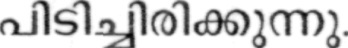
പിടിച്ചിരിക്കുന്നു.
